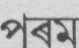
পৰম
